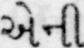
એની
